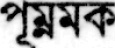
পূম্নমক
